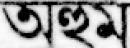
অহুম
